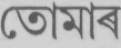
তোমাৰ
